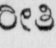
ರೀತಿ
